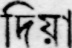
দিয়া
